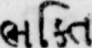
ભક્તિ
